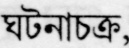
ঘটনাচক্র,
